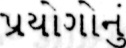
પ્રયોગોનું
